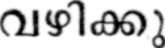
വഴിക്കു
